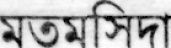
মতমসিদা
